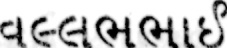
વલ્લભભાઈ
